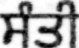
ਸੰਤੀ
